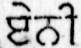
ਏਨੀ
